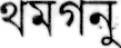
থমগনু
